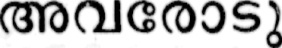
അവരോടു
